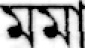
মমা
